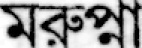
মরুপ্না
